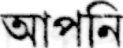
আপনি
